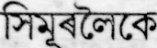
সিমূৰলৈকে
